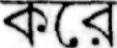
করে
